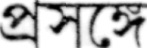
প্রসঙ্গে
